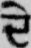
ਦੇ
